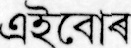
এইবোৰ
